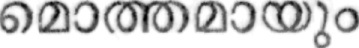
മൊത്തമായും
